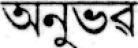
অনুভৱ
